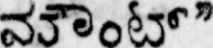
ಮೌಂಟ್”
